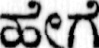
ಹೇಗೆ
